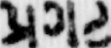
પ્રગટ
